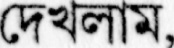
দেখলাম,
